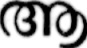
ആ
